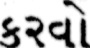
કરવો
